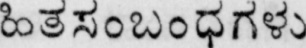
ಹಿತಸಂಬಂಧಗಳು
